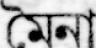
মৈনা
